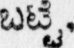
ಬಟ್ಟೆ,
